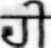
ਹੀ
